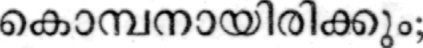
കൊമ്പനായിരിക്കും;
